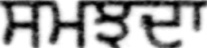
ਸਮਝਦਾ
